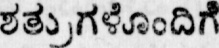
ಶತ್ರುಗಳೊಂದಿಗೆ
